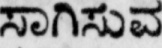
ಸಾಗಿಸುವ
